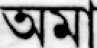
অমা
